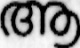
ആ
